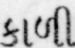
કાળી
